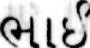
ભાઈ
